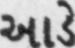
આડે
